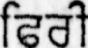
ਫਿਰੀ
